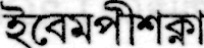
ইবেমপীশক্না
